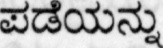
ಪಡೆಯನ್ನು
